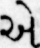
એ
